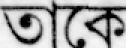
তাকে
